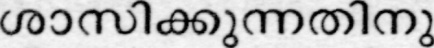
ശാസിക്കുന്നതിനു
